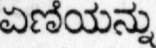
ಏಣಿಯನ್ನು
